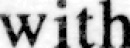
with
